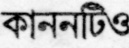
কাননটিও
